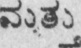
ಮತ್ತು
